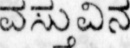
ವಸ್ತುವಿನ
